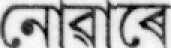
নোৱাৰে
